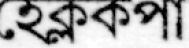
হেক্লকপা
